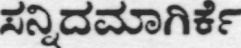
ಸನ್ನಿದಮಾಗಿರ್ಕೆ
